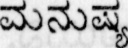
ಮನುಷ್ಯ
